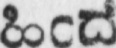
ಹಿಂದೆ
